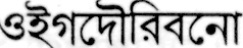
ওইগদৌরিবনো
